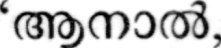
'ആനാല്‍,
